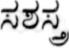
ಸಶಸ್ತ್ರ
